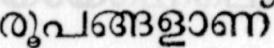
രൂപങ്ങളാണ്
